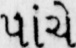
પાંચે
